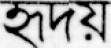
হৃদয়
